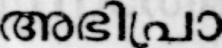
അഭിപ്രാ
